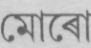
মোৰো
